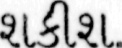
શકીશ.
